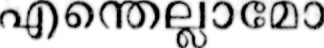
എന്തെല്ലാമോ
